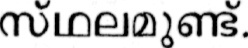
സ്ഥലമുണ്ട്.
